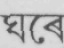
ঘৰে
